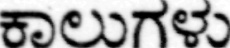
ಕಾಲುಗಳು
